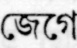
জেগে
